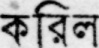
করিল
